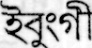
ইবুংগী
